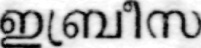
ഇബ്രീസ
